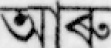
আৰু
